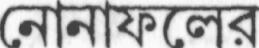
নোনাফলের
